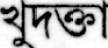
খুদক্তা
